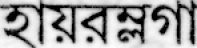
হায়রম্লগা
